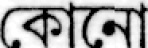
কোনো
